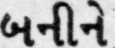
બનીને
